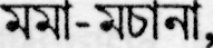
মমা-মচানা,
